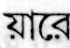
য়ারে
